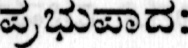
ಪ್ರಭುಪಾದ:
